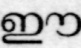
ഈ
